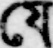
যে
